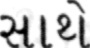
સાથે
